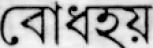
বোধহয়
